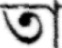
তা
